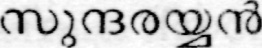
സുന്ദരയ്യന്‍
